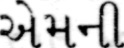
એમની
